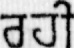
ਰਹੀ
